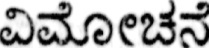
ವಿಮೋಚನೆ
